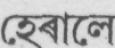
হেৰালে
